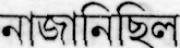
নাজানিছিল
